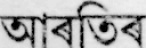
আৰতিৰ
